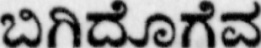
ಬಿಗಿದೊಗೆವ
